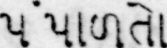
પંપાળતો
